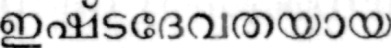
ഇഷ്ടദേവതയായ
